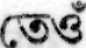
তেওঁ
